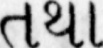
તથા
